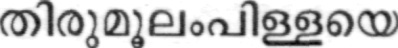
തിരുമൂലംപിള്ളയെ
